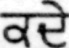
ਕਦੇ
